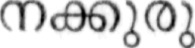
നക്കുരു
